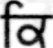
ਕਿ
